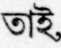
তাই,
